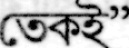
তেকই”
